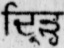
ਦ੍ਰਿੜ੍ਹ
